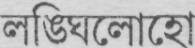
লঙিঘলোহো
